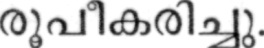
രൂപീകരിച്ചു.
